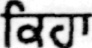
ਕਿਹਾ
